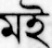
মই
